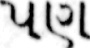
પણ
